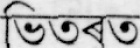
ভিতৰত
